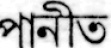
পানীত
